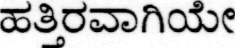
ಹತ್ತಿರವಾಗಿಯೇ
